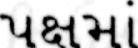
પક્ષમાં
